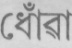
ধোঁৱা
